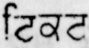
ਟਿਕਟ
